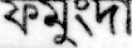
ফমুংদা
